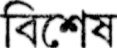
বিশেষ
